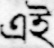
এই
